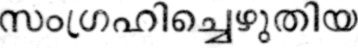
സംഗ്രഹിച്ചെഴുതിയ
